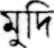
মুদি
